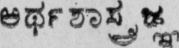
ಅರ್ಥಶಾಸ್ತ್ರಜ್ಞ
